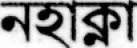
নহাক্না
